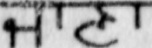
ਜਾਣਾ
